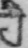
ਹੈ
